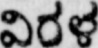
ವಿರಳ
